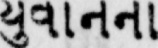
યુવાનના
